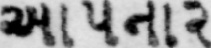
આપનાર
